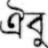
ঐবু
